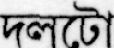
দলটো
